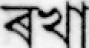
ৰখা
